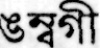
ঙম্বগী
